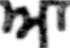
ਆ
